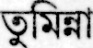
তুমিন্না
